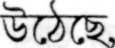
উঠেছে,
